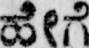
ಹೇಗೆ
